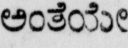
ಅಂತೆಯೇ
